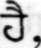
ਹੈ,
